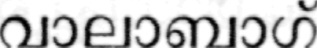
വാലാബാഗ്
